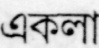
একলা
